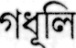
গধূলি
